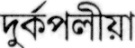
দুর্কপলীয়া
